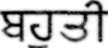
ਬਹੁਤੀ
